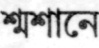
শ্মশানে
